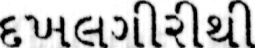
દખલગીરીથી
